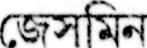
জেসমিন
